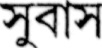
সুবাস
